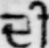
ਦੀ
